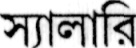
স্যালারি
